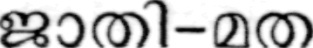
ജാതി-മത
